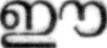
ഈ
